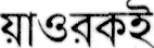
য়াওরকই
